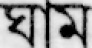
ঘাম
